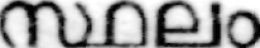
സ്ഥലം
